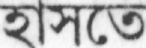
হাসতে
